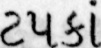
ટપકાં
